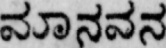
ಮಾನವನ
